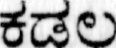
ಕಡಲ
